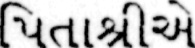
પિતાશ્રીએ
